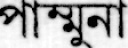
পাম্মুনা
